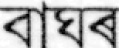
বাঘৰ
